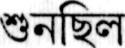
শুনছিল
